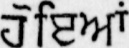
ਹੋਇਆਂ
